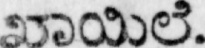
ಖಾಯಿಲೆ.
